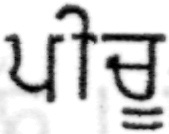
ਪੀਚੂ
